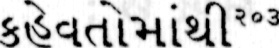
કહેવતોમાંથી૨૦૩
